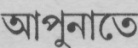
আপুনাতে
